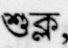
শুক্ল,
